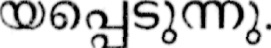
യപ്പെടുന്നു.
